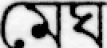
মেঘ
